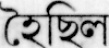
হৈছিল
